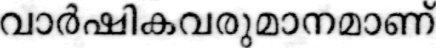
വാര്‍ഷികവരുമാനമാണ്
